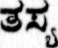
ತಸ್ಯ
